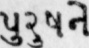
પુરુષને
